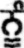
ਨੂੰ
